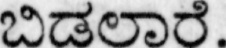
ಬಿಡಲಾರೆ.
